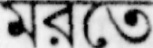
মরতে
